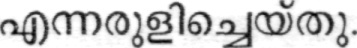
എന്നരുളിച്ചെയ്തു.
